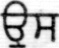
ਉਸ
